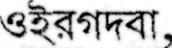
ওইরগদবা,
